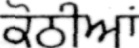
ਕੋਠੀਆਂ
